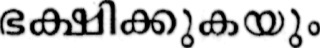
ഭക്ഷിക്കുകയും
